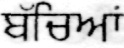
ਬੱਚਿਆਂ
